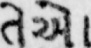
તેઓ
